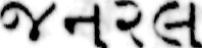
જનરલ
